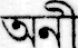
অনী
